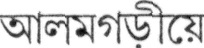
আলমগড়ীয়ে
